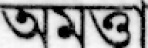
অমত্তা
